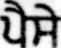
ਪੈਸੇ
